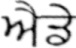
ਐਡੇ
